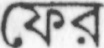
ফের
